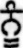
ਨੂੰ
